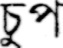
চুপ
